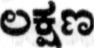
ಲಕ್ಷಣ
